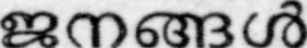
ജനങ്ങള്‍
